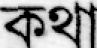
কথা
